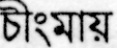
চীংমায়
